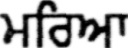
ਮਰਿਆ
